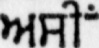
ਅਸੀਂ
